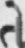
તે
